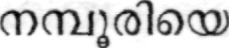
നമ്പൂരിയെ
